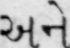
અને
